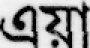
এয়া
